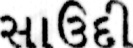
સાઉદી
